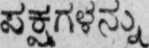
ಪಕ್ಷಗಳನ್ನು
